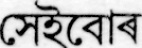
সেইবোৰ
